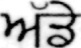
ਅੱਡੇ
